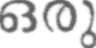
ഒരു
